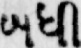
બધી
